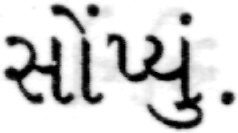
સોંપ્યું.
